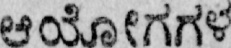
ಆಯೋಗಗಳ
